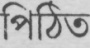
পিঠিত
